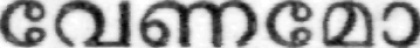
വേണമോ
